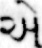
એ
